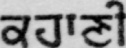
ਕਹਾਣੀ
